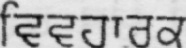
ਵਿਵਹਾਰਕ
